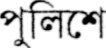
পুলিশে
